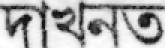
দাখনত
